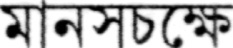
মানসচক্ষে
